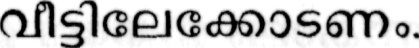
വീട്ടിലേക്കോടണം.
